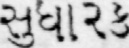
સુધારક
